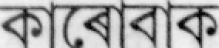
কাৰোবাক
